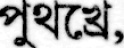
পুথখ্রে,
